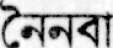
নৈনবা
